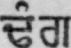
ਢੰਗ
